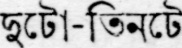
দুটো-তিনটে
